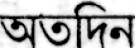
অতদিন
